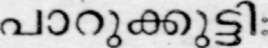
പാറുക്കുട്ടി:
